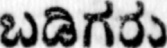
ಬಡಿಗರು
